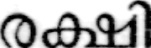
രക്ഷി
